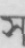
স
